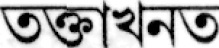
তক্তাখনত
